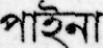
পাইনা
